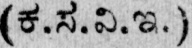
(ಕ.ಸ.ವಿ.ಇ.)
